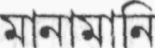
মানামানি
